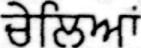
ਚੇਲਿਆਂ
